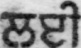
ਲਈ
